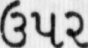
ઉપર
